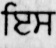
ਇਸ
